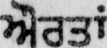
ਔਰਤਾਂ
